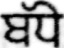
ਬੱਧੇ
